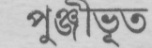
পুঞ্জীভূত
